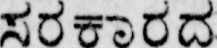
ಸರಕಾರದ
